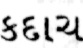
કદાચ
